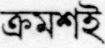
ক্রমশই
